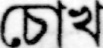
চোখ
